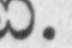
ಐ.
